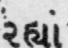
રહ્યા
